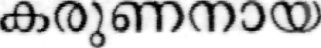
കരുണനായ
